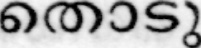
തൊടു
